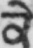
ਕੇ
